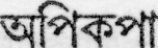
অপিকপা
